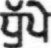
ਧੁੱਪੇ
